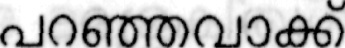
പറഞ്ഞവാക്ക്
